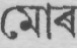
মোৰ
